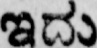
ಇದು
